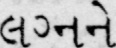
લગ્નને
